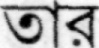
তার
